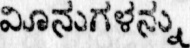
ಮೀನುಗಳನ್ನು
